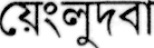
য়েংলুদবা
